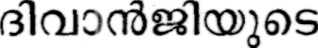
ദിവാന്‍ജിയുടെ
